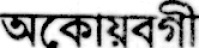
অকোয়বগী
